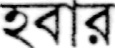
হবার
